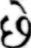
છે
